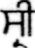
ਸ੍ਰੀ
